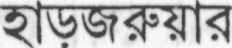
হাড়জরুয়ার
